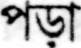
পড়া
